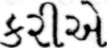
કરીએ
